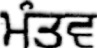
ਮੰਤਵ
